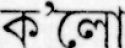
ক'লো
